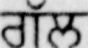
ਗੱਲ
